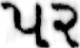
પર
